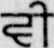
ਵੀ
